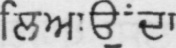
ਲਿਆਉਂਦਾ
